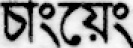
চাংয়েং
